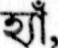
হ্যাঁ,
